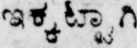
ಇಕ್ಕಟ್ಟಾಗಿ
